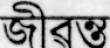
জীৱন্ত
